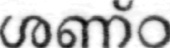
ശണ്ഠ
